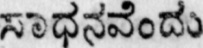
ಸಾಧನವೆಂದು
